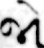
જો
